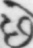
છે
